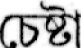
চেষ্টা
